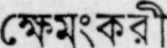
ক্ষেমংকরী
